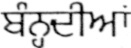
ਬੰਨ੍ਹਦੀਆਂ
